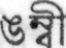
ঙম্বী
